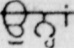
ਉਨ੍ਹਾਂ
